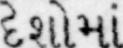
દેશોમાં
